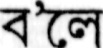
ব'লে
